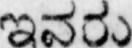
ಇವರು
